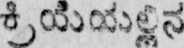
ಕ್ರಿಯೆಯಲ್ಲಿನ
